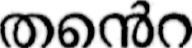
തന്റെ
